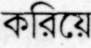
করিয়ে
